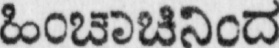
ಹಿಂಚಾಚಿನಿಂದ
